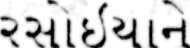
રસોઈયાને
